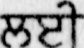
ਲਈ
